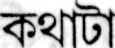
কথাটা
